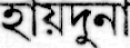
হায়দুনা
